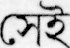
সেই
